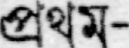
প্রথম-
